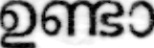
ഉണ്ടാ
